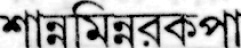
শান্নমিন্নরকপা
